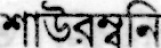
শাউরম্বনি
